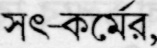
সত্-কর্মের,
